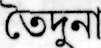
তৈদুনা
